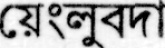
য়েংলুবদা
